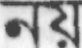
নয়
